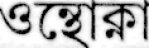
ওন্থোক্না
